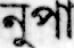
নুপা
